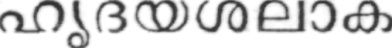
ഹൃദയശലാക
